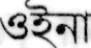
ওইনা
